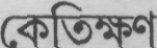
কেতিক্ষণ
